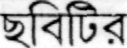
ছবিটির
